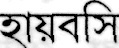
হায়বসি
